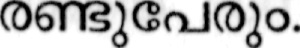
രണ്ടുപേരും.
